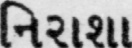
નિરાશા
